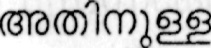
അതിനുള്ള
